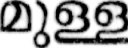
മുള്ള
